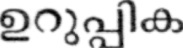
ഉറുപ്പിക
